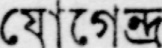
যোগেন্দ্র
